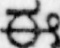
ಈ
